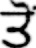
ਤੋਂ
